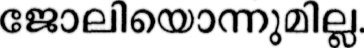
ജോലിയൊന്നുമില്ല.
